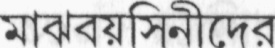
মাঝবয়সিনীদের
